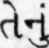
તેનું
